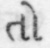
તો
